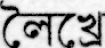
লৈখ্রে
